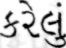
કરેલું
